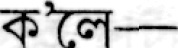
ক'লে-
